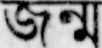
জন্ম
